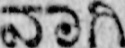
ವಾಗಿ
